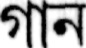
গান
